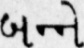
બન્ને
